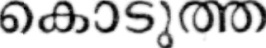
കൊടുത്ത
